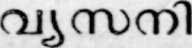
വ്യസനി
